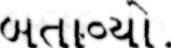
બતાવ્યો.
